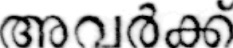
അവര്‍ക്ക്
